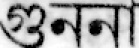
গুননা
